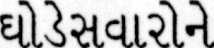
ઘોડેસવારોને
